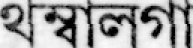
থম্বালগা
